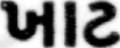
ખાટ
